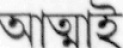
আত্মাই
